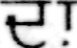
ਦਾ
